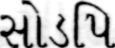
સોડપિ
